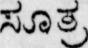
ಸೂತ್ರ
